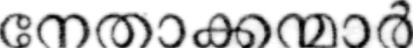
നേതാക്കന്മാര്‍
